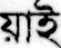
য়াই
